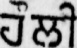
ਹੌਲੀ
